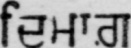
ਦਿਮਾਗ਼
